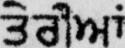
ਤੇਰੀਆਂ
